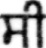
ਸੀ
